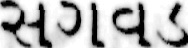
સગવડ
